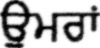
ਉਮਰਾਂ
